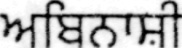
ਅਬਿਨਾਸ਼ੀ
